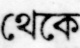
থেকে
